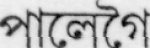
পালেগৈ
